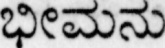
ಭೀಮನು
